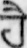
ਹੈ
